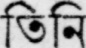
তিনি
